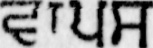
ਵਾਪਸ
